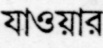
যাওয়ার
